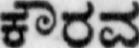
ಕೌರವ
